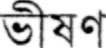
ভীষণ
